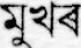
মুখৰ
